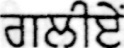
ਗਲੀਏਂ
